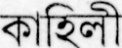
কাহিলী
